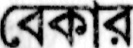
বেকার
